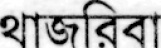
থাজরিবা
